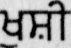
ਖੁਸ਼ੀ
